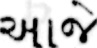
આજે
